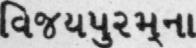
વિજયપુરમના
